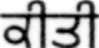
ਕੀਤੀ
